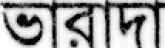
ভারাদা
